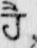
ਹੈ,
